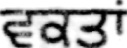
ਵਕਤਾਂ
